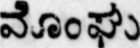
ಮೊಂಘು
